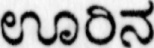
ಊರಿನ
